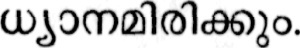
ധ്യാനമിരിക്കും.
